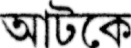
আটকে
